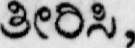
ತೀರಿಸಿ,
